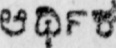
ಆರ್ಥಿಕ
